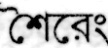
শৈরেং
